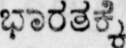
ಭಾರತಕ್ಕೆ
